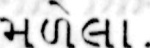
મળેલા.
